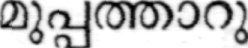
മുപ്പത്താറു
